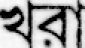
খরা
